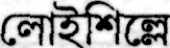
লোইশিল্লে
